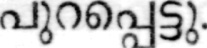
പുറപ്പെട്ടു.
